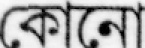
কোনো
